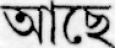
আছে
